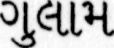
ગુલામ
